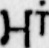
ਮਾਂ
